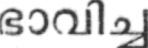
ഭാവിച്ച
